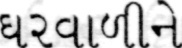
ઘરવાળીને
